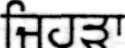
ਜਿਹੜਾ
